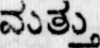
ಮತ್ತು
